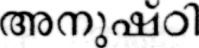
അനുഷ്ഠി
